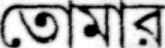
তোমার
